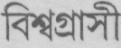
বিশ্বগ্ৰাসী
